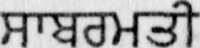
ਸਾਬਰਮਤੀ
